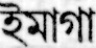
ইমাগা
